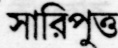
সারিপুত্ত
